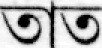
তাত
